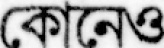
কোনেও
